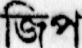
জিপ
